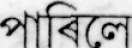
পাৰিলে
